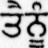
ਤੈਨੂੰ
